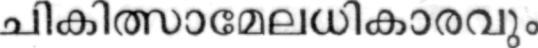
ചികിത്സാമേലധികാരവും
